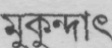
মুকুন্দাৎ
